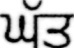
ਘੱਤ
